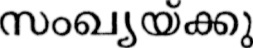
സംഖ്യയ്ക്കു
